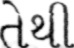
તેથી
